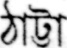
ঠাট্টা
